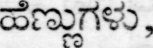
ಹೆಣ್ಣುಗಳು,
